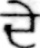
ਦੇ
